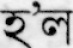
হ'ল
